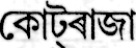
কোট্‌ৰাজা
